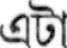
এটা
